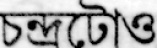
চন্দ্রটোও
